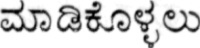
ಮಾಡಿಕೊಳ್ಳಲು
